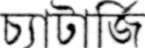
চ্যাটার্জি
